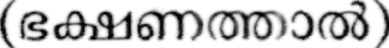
(ഭക്ഷണത്താല്‍)
